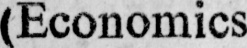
(Economics
